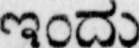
ಇಂದು
